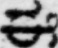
ಈ
